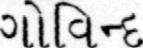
ગોવિન્દ
